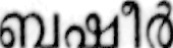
ബഷീര്‍
